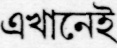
এখানেই
